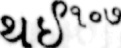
થઈ૧૦૭
